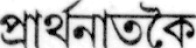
প্রার্থনাতকৈ
